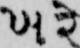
ખરે
